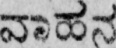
ವಾಹನ
